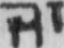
ਜਾ
